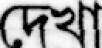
দেখা
